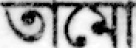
তামো
